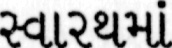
સ્વારથમાં
